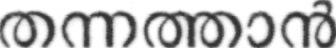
തന്നത്താന്‍
